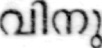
വിനു
